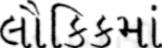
લૌકિકમાં
